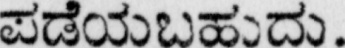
ಪಡೆಯಬಹುದು.
